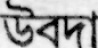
উবদা
